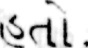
હતો.
